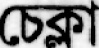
চেক্লা
